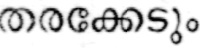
തരക്കേടും
